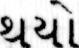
થયો
